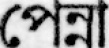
পেন্না
